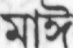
মাঈ
